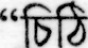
"চিঠি
